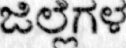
ಜಿಲ್ಲೆಗಳ
